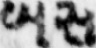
બસ
